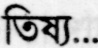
তিষ্য...
